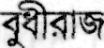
বুধীরাজ
